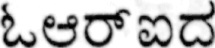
ಓಆರ್ ಐದ
